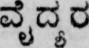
ವೈದ್ಯರ
